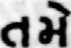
તમે
